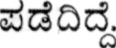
ಪಡೆದಿದ್ದೆ.
